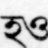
হও
